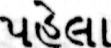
પહેલા
